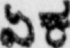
ಏಕ
